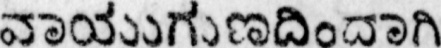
ವಾಯುಗುಣದಿಂದಾಗಿ
